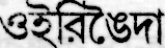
ওইরিঙৈদা
